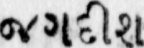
જગદીશ
